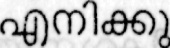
എനിക്കു
